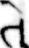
તે
